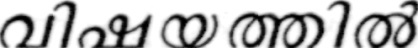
വിഷയത്തില്‍
